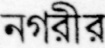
নগরীর
